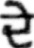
ਦੇ
